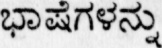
ಭಾಷೆಗಳನ್ನು
